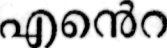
എന്റെ
